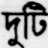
দুটি
